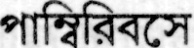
পাম্বিরিবসে
